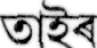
তাইৰ
